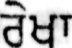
ਰੇਖਾ
